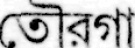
তৌরগা
